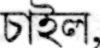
চাইল,
